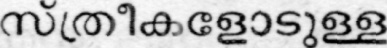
സ്ത്രീകളോടുള്ള
